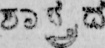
ಶಾಸ್ತ್ರದ
